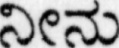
ನೀನು
